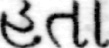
હતા
